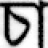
চা
